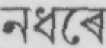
নধৰে
